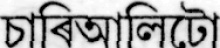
চাৰিআলিটো
